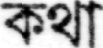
কথা
